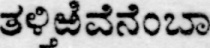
ತಳ್ತಿಱವೆನೆಂಬಾ
